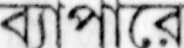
ব্যাপারে
